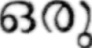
ഒരു
